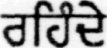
ਰਹਿੰਦੇ
